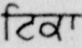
ਟਿਕਾ
